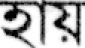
হায়
